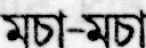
মচা-মচা
